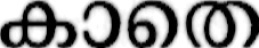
കാതെ
